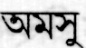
অমসু
